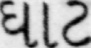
ઘાટ
